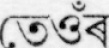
তেওঁৰ
